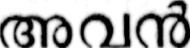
അവന്‍
